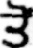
ਤੋਂ
